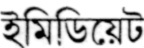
ইমিডিয়েট
